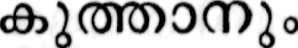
കുത്താനും
